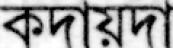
কদায়দা
